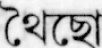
থৈছো
